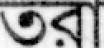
তরা
